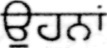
ਉਹਨਾਂ
